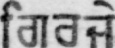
ਗਿਰਜੇ
